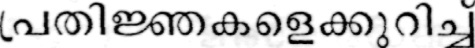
പ്രതിജ്ഞകളെക്കുറിച്ച്
